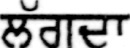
ਲੱਗਦਾ
